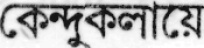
কেন্দুকলায়ে
